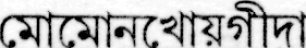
মোমোনখোয়গীদা
